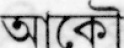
আকৌ
